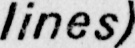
lines)
